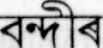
বন্দীৰ
